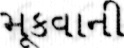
મૂકવાની
